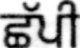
ਛੱਪੀ
